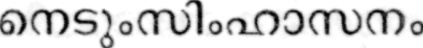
നെടുംസിംഹാസനം
